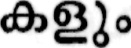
കളും
